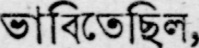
ভাবিতেছিল,
